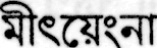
মীৎয়েংনা
